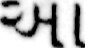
આ
